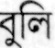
বুলি
